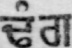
ਢੰਗ
